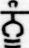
ਨੂੰ
